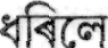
ধৰিলে
